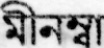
মীনম্বা
